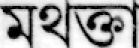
মথক্তা
